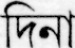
দিনা
